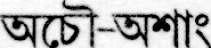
অচৌ-অশাং
